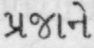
પ્રજાને
